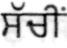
ਸੱਚੀਂ
